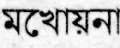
মখোয়না
